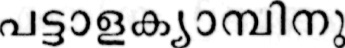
പട്ടാളക്യാമ്പിനു
